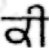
ਕੀ
